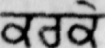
ਕਰਕੇ
